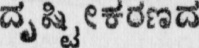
ದೃಷ್ಟೀಕರಣದ
